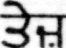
ਤੇਜ਼
